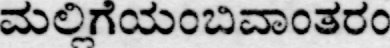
ಮಲ್ಲಿಗೆಯಂಬಿವಾಂತರಂ
